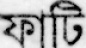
ফাটি
